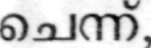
ചെന്ന്,
